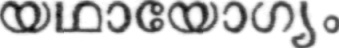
യഥായോഗ്യം
